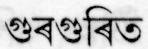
গুৰগুৰিত
